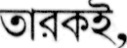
তারকই,
